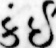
કંઈ
